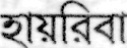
হায়রিবা
